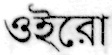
ওইরো
